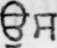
ਉਸ
